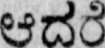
ಆದರೆ
